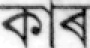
কাৰ
